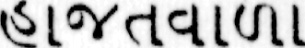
હાજતવાળા
